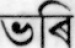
ভৰি
